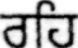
ਰਹਿ
